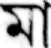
মা
